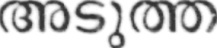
അടുത്ത
